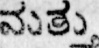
ಮತ್ತು
